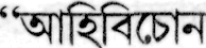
"আহিবিচোন
